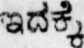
ಇದಕ್ಕೆ
